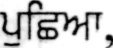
ਪੁਛਿਆ,
